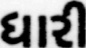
ધારી
